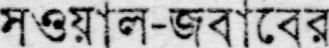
সওয়াল-জবাবের
